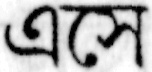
এসে
